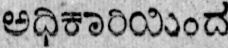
ಅಧಿಕಾರಿಯಿಂದ
